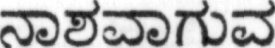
ನಾಶವಾಗುವ
